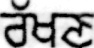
ਰੱਖਣ
